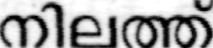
നിലത്ത്
